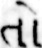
તો
